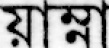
য়াম্না
